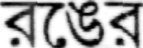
রঙের
